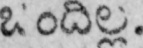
ಬಂದಿಲ್ಲ.
